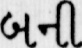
બની
